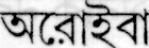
অরোইবা
